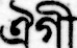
ঐগী
